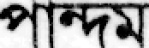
পান্দম
